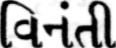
વિનંતી
